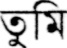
তুমি
